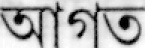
আগত
